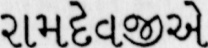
રામદેવજીએ
